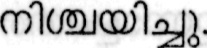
നിശ്ചയിച്ചു.
